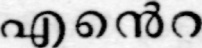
എന്റെ
